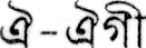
ঐ-ঐগী
